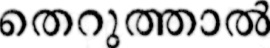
തെറുത്താല്‍
